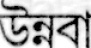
উন্নবা
